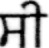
ਸੀ
